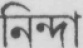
নিন্দা
